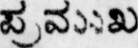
ಪ್ರಮುಖ
